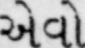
એવો
